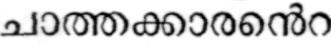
ചാത്തക്കാരന്റെ
